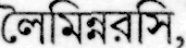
লৈমিন্নরসি,
